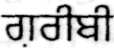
ਗ਼ਰੀਬੀ
